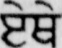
ਏਥੇ
